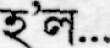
হ'ল...
